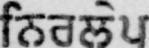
ਨਿਰਲੇਪ
